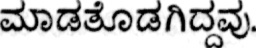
ಮಾಡತೊಡಗಿದ್ದವು.
